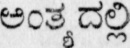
ಅಂತ್ಯದಲ್ಲಿ
